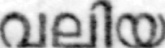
വലിയ
